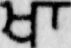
ਖਾ
